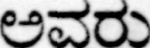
ಅವರು
